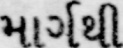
માર્ગથી
